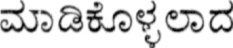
ಮಾಡಿಕೊಳ್ಳಲಾದ
